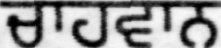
ਚਾਹਵਾਨ
